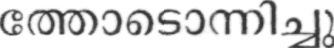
ത്തോടൊന്നിച്ചു
